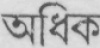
অধিক
